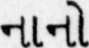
નાનો
